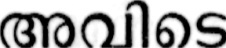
അവിടെ
